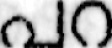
പറ
